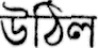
উঠিল
